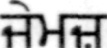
ਜੇਮਜ਼
